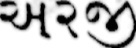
અરજી
